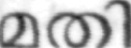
മതി
